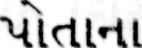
પોતાના
